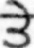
ਤੇ
